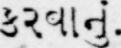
કરવાનું.
